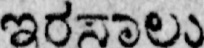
ಇರಸಾಲು
